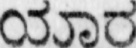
ಯಾರ
